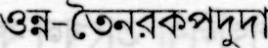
ওন্ন-তৈনরকপদুদা
